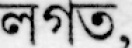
লগত,
